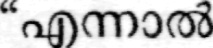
“എന്നാല്‍
